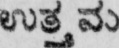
ಉತ್ತಮ
